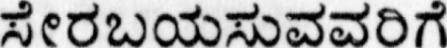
ಸೇರಬಯಸುವವರಿಗೆ
